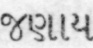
જણાય
